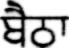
ਬੈਠਾ
